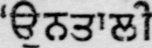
'ਉਨਤਾਲੀ
